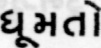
ધૂમતો
